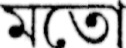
মতো
